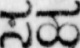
ಸಹ
